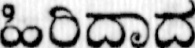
ಹಿರಿದಾದ
